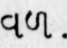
વળ.
